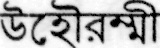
উহৌরম্মী
